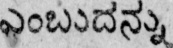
ಎಂಬುದನ್ನು
